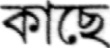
কাছে
